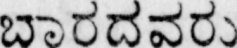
ಬಾರದವರು
